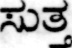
ಸುತ್ತ
